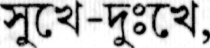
সুখে-দুঃখে,
